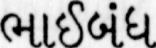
ભાઈબંધ
